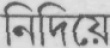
নিদিয়ে
